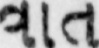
વાત
